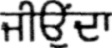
ਜੀਉਂਦਾ
